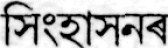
সিংহাসনৰ
